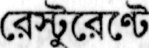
রেস্টুরেণ্টে
